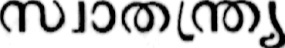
സ്വാതന്ത്ര്യ
